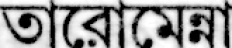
তারোমেন্না
